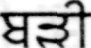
ਬੜੀ
